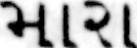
મારા
